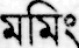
মমিং
